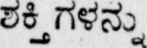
ಶಕ್ತಿಗಳನ್ನು
